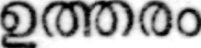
ഉത്തരം
